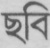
ছবি
